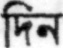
দিন
